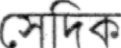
সেদিক
